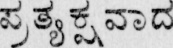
ಪ್ರತ್ಯಕ್ಷವಾದ
